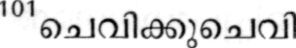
101ചെവിക്കുചെവി
